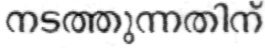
നടത്തുന്നതിന്
